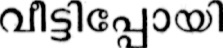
വീട്ടിപ്പോയി
